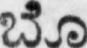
ಬೊ
